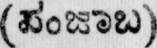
(ಪಂಜಾಬ)
